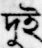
দুই
